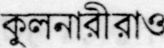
কুলনারীরাও
